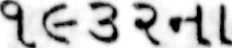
૧૯૩૨ના
